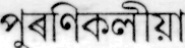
পুৰণিকলীয়া
